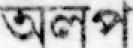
অলপ
